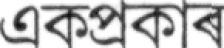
একপ্রকাৰ
